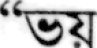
"ভয়
